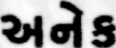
અનેક
